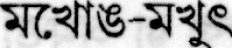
মখোঙ-মখুৎ
